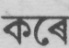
কৰে
